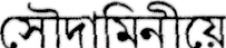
সৌদামিনীয়ে
